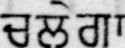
ਚਲੇਗਾ
